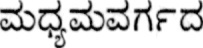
ಮಧ್ಯಮವರ್ಗದ
